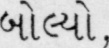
બોલ્યો,
